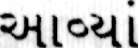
આવ્યાં
